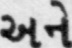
અને
